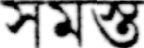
সমস্ত
